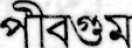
পীবগুম
